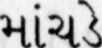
માંચડે
